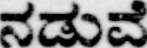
ನಡುವೆ
